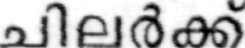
ചിലര്‍ക്ക്
